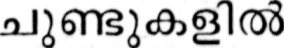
ചുണ്ടുകളില്‍
